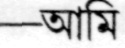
–আমি
